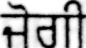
ਜੋਗੀ
